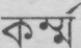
কৰ্ম্ম
